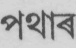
পথাৰ
